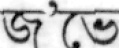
জ'ভে
